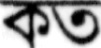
কত
